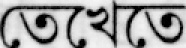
তেখেতে
